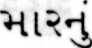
મારનું
